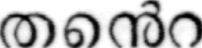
തന്റെ
